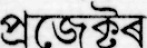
প্রজেক্টৰ
